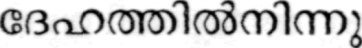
ദേഹത്തില്‍നിന്നു
